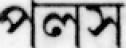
পলস
